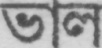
ভাল
